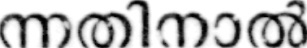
ന്നതിനാല്‍
